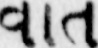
વાત
